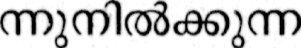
ന്നുനില്‍ക്കുന്ന
